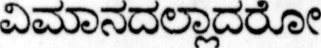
ವಿಮಾನದಲ್ಲಾದರೋ
